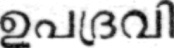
ഉപദ്രവി
